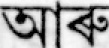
আৰু
